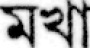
মখা
